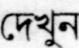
দেখুন
